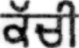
ਕੱਚੀ
